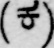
(ಕ)
